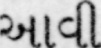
આવી
